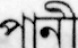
পানী
